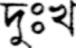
দুঃখ
